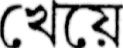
খেয়ে
